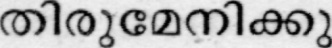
തിരുമേനിക്കു
